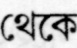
থেকে
